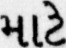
માટે
